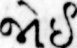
જોઈ
